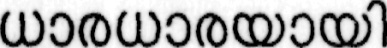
ധാരധാരയായി
